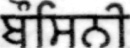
ਬੌਸਿਨੀ
